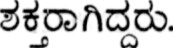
ಶಕ್ತರಾಗಿದ್ದರು.
